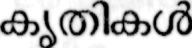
കൃതികള്‍
